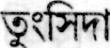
তুংসিদা
